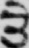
ਤੇ
